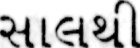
સાલથી
